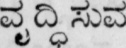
ವೃದ್ಧಿಸುವ
